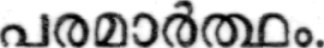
പരമാര്‍ത്ഥം.
